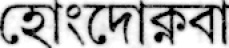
হোংদোক্নবা
